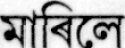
মাৰিলে
